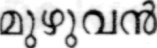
മുഴുവന്‍
